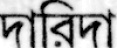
দারিদা
